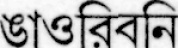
ঙাওরিবনি
